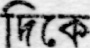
দিকে
